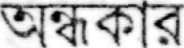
অন্ধকার
